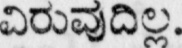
ವಿರುವುದಿಲ್ಲ.
